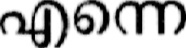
എന്നെ
